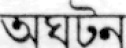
অঘটন
